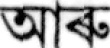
আৰু
